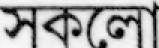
সকলো
